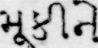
મૂકીને
